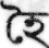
হৈ
